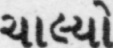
ચાલ્યો
